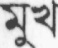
মুখ
